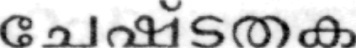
ചേഷ്ടതക
